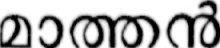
മാത്തന്‍
